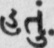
હતું.
